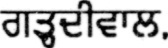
ਗੜ੍ਹਦੀਵਾਲ,
